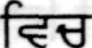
ਵਿਚ
